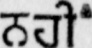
ਨਹੀਂ
